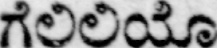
ಗೆಲಿಲಿಯೊ
